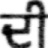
ਦੀ
